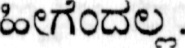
ಹೀಗೆಂದಲ್ಲ.
